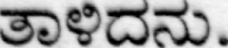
ತಾಳಿದನು.
